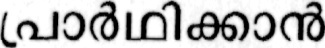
പ്രാര്‍ഥിക്കാന്‍
